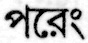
পরেং
